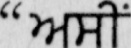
''ਅਸੀਂ
